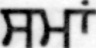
ਸਮਾਂ
